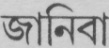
জানিবা
